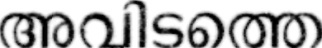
അവിടത്തെ
